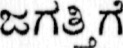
ಜಗತ್ತಿಗೆ
